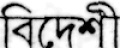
বিদেশী
